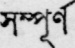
সম্পূর্ণ
